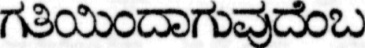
ಗತಿಯಿಂದಾಗುವುದೆಂಬ
